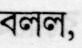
বলল,
